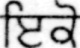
ਇਕੋ
